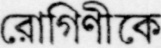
রোগিণীকে
